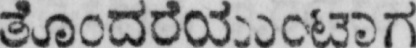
ತೊಂದರೆಯುಂಟಾಗ
